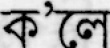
ক'লে
